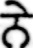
ਨੇ
